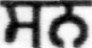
ਸਨ
